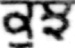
ਕੁਝ
